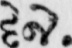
દેજે.
